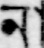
না
